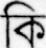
কি
